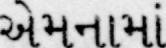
એમનામાં
